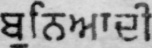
ਬੁਨਿਆਦੀ
